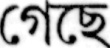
গেছে
